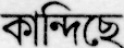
কান্দিছে
